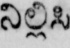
ನಿಲ್ಲಿಸಿ
